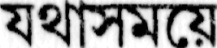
যথাসময়ে
